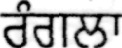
ਰੰਗਲਾ
